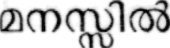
മനസ്സില്‍
